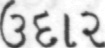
ઉદાર
